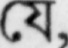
যে,
